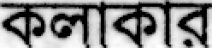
কলাকার
